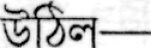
উঠিল-
